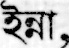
ইন্না,
